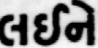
લઈને
